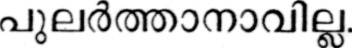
പുലര്‍ത്താനാവില്ല.
